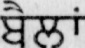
ਬੈਲਾਂ
